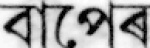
বাপেৰ
